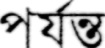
পর্যন্ত
